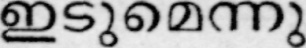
ഇടുമെന്നു
